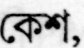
কেশ,
